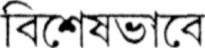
বিশেষভাবে
